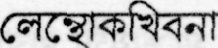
লেন্থোকখিবনা
